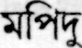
মপিদু
